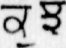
ਕੁਝ
